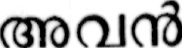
അവന്‍
